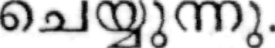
ചെയ്യുന്നു.
